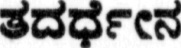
ತದರ್ಧೇನ
